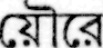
য়ৌরে
